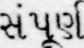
સંપૂર્ણ
